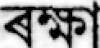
ৰক্ষা
